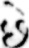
છે
